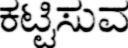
ಕಟ್ಟಿಸುವ
